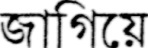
জাগিয়ে
